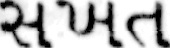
સખત
